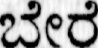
ಬೇರೆ
